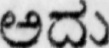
ಅದು
